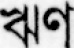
ঋণ
